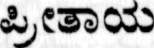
ಪ್ರೀತಾಯ
